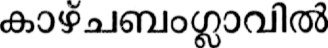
കാഴ്ചബംഗ്ലാവില്‍
